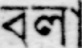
বলা
